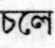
চলে
